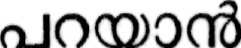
പറയാന്‍
